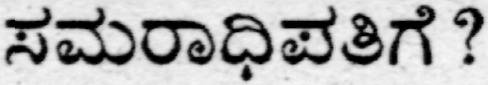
ಮರಣವನ್ನು
